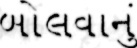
બોલવાનું
